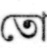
তো
